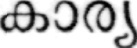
കാര്യ
